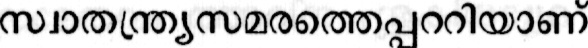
സ്വാതന്ത്ര്യസമരത്തെപ്പററിയാണ്
